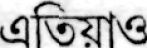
এতিয়াও
